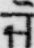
ਜੋ
